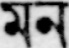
মন
